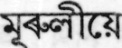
মূৰুলীয়ে
